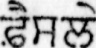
ਫ਼ੈਸਲੇ
